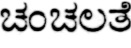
ಚಂಚಲತೆ
